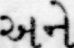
અને
